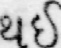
થઈ
